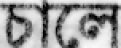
চালে
